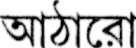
আঠারো
